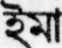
ইমা
